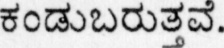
ಕಂಡುಬರುತ್ತವೆ.
